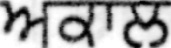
ਅਕਾਲ
